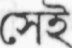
সেই
